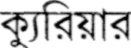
ক্যুরিয়ার
